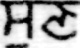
ਸੁਣ
